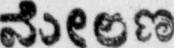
ಮೇಲಣ
